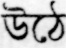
উঠে
